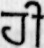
ਹੀ
